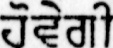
ਹੋਵੇਗੀ
